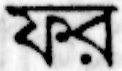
ফর
